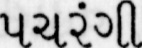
પચરંગી
